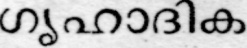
ഗൃഹാദിക
